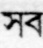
সব
